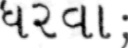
ધરવા;
